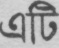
এটি
